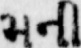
મની
